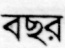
বছর
